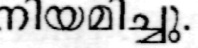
നിയമിച്ചു.
